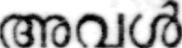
അവള്‍
